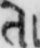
તો
